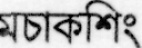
মচাকশিং
